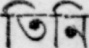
তিনি
